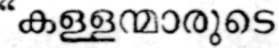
“കള്ളന്മാരുടെ
